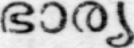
ഭാര്യ
